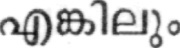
എങ്കിലും
